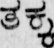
ತಕ್ಕ
